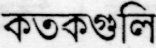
কতকগুলি
